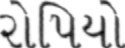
રોપિયો
